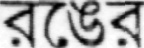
রঙের
